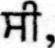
ਸੀ,
